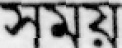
সময়
